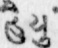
હૈયું
